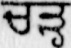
ਚੜ੍ਹ
